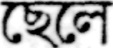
ছেলে
